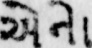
એનો
